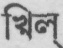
খিল্
